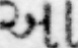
આ
